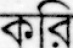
করি
